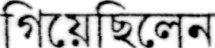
গিয়েছিলেন
